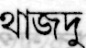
থাজদু
